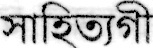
সাহিত্যগী
